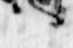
પણ
